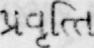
પ્રવૃત્તિ
